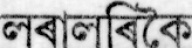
লৰালৰিকৈ
